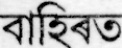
বাহিৰত
